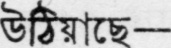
উঠিয়াছে—
